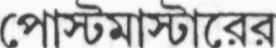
পোস্টমাস্টারের
